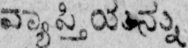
ವ್ಯಾಪ್ತಿಯನ್ನು
